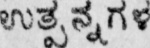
ಉತ್ಪನ್ನಗಳ
